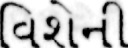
વિશેની
